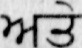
ਅਤੇ
